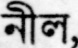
নীল,
